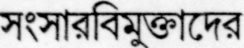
সংসারবিমুক্তাদের
